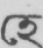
হে
